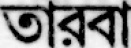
তারবা
